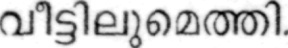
വീട്ടിലുമെത്തി.
